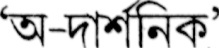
‘অ-দার্শনিক'
